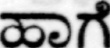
ಹಾಗೆ
